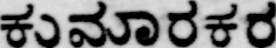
ಕುಮಾರಕರ
